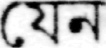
যেন
